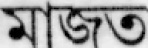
মাজত
